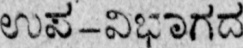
ಉಪ-ವಿಭಾಗದ
